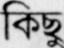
কিছু
